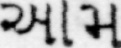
આમ
